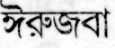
ঈরুজবা
